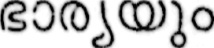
ഭാര്യയും
